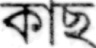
কাছ
